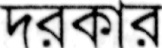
দরকার
